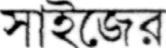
সাইজের
